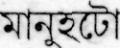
মানুহটো
